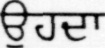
ਉਹਦਾ
